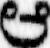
ಆ
